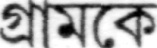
গ্রামকে
